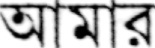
আমার
